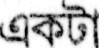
একটা
